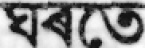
ঘৰতে
